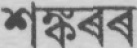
শঙ্কৰৰ
